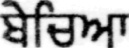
ਬੇਚਿਆ
